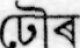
ঢৌৰ
